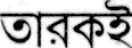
তারকই
